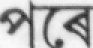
পৰে
